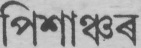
পিশাঞ্চৰ
